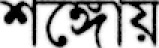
শঙ্গোয়
